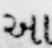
આ
